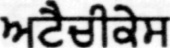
ਅਟੈਚੀਕੇਸ
